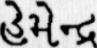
હેમેન્દ્ર
